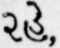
રહે,
